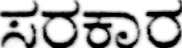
ಸರಕಾರ
